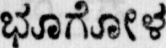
ಭೂಗೋಳ
